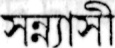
সন্ন্যাসী
